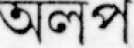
অলপ
